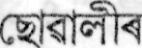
ছোৱালীৰ
